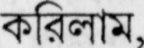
করিলাম,
